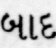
બાદ
